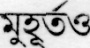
মুহূর্তও
